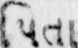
પિતા
